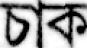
চাক
